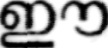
ഈ
